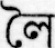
লৈ
